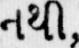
નથી,
